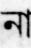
না
